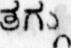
ತಗ್ಗು
